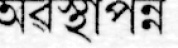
অৱস্হাপন্ন
